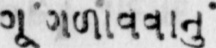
ગૂંગળાંવવાનું
